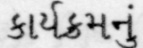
કાર્યક્રમનું
